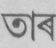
তাৰ
